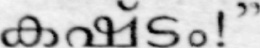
കഷ്ടം!"
